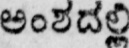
ಅಂಶದಲ್ಲಿ
